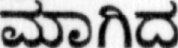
ಮಾಗಿದ
